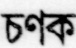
চণক
